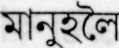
মানুহলৈ
